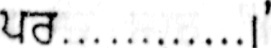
ਪਰ........।'
